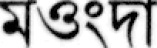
মওংদা
